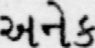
અનેક
